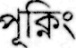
পূক্নিং
